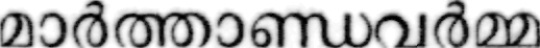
മാര്‍ത്താണ്ഡവര്‍മ്മ
